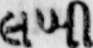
લખી
